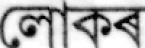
লোকৰ
